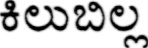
ಕಿಲುಬಿಲ್ಲ
